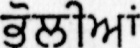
ਭੋਲੀਆਂ
